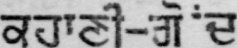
ਕਹਾਣੀ-ਗੋਂਦ
